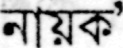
নায়ক’
